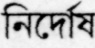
নির্দোষ
